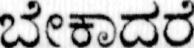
ಬೇಕಾದರೆ
